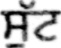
ਸੁੱਟ
